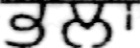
ਭਲਾ
